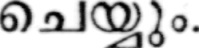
ചെയ്യും.
